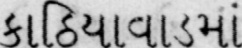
કાઠિયાવાડમાં
